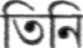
তিনি
